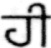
ਹੀ
